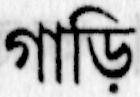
গাড়ি
